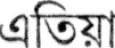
এতিয়া
